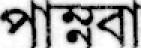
পাম্নবা
